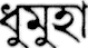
ধুমুহা
